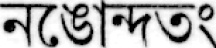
নঙোন্দতং
